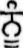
ਨੂੰ
